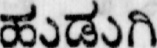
ಹುಡುಗಿ
